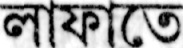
লাফাতে
